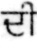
ਦੀ
